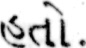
હતો.
